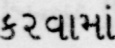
કરવામાં
